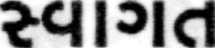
સ્વાગત
